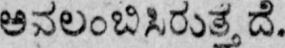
ಅವಲಂಬಿಸಿರುತ್ತದೆ.
